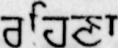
ਰਹਿਣਾ
